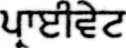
ਪ੍ਰਾਈਵੇਟ
